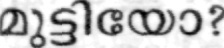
മുട്ടിയോ?
